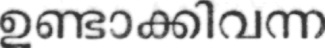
ഉണ്ടാക്കിവന്ന
